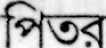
পিতর
